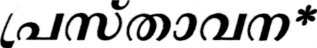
പ്രസ്താവന*
